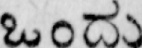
ಒಂದು
